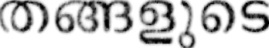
തങ്ങളുടെ
